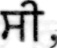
ਸੀ,
